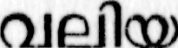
വലിയ
